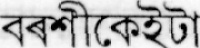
বৰশীকেইটা
